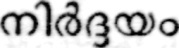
നിര്‍ദ്ദയം
